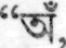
"অঁ,
